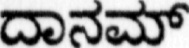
ದಾನಮ್
